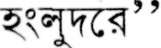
হংলুদরে”
